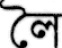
লৈ
